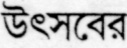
উত্সবের
